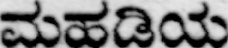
ಮಹಡಿಯ
